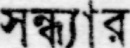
সন্ধ্যার
